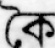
কৈ
